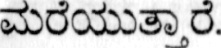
ಮರೆಯುತ್ತಾರೆ.
